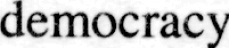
democracy
